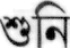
শুনি
